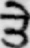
ਤੇ
